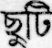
ছুটি
